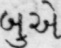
બુએ
